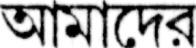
আমাদের
